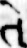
તે
